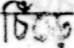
চিঁড়ে
